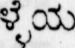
ಳ್ಳೆಯ
